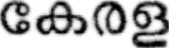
കേരള
